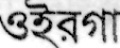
ওইরগা
